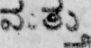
ಮತ್ತು
